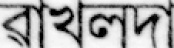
ৱাখলদা
